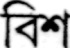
বিশ
